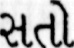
સતો
